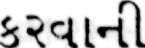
કરવાની
